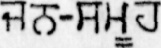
ਜਨ-ਸਮੂਹ
